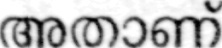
അതാണ്
